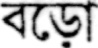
বড়ো
